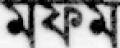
মফম
